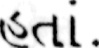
હતાં.
